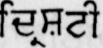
ਦ੍ਰਿਸ਼ਟੀ
